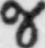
જ
